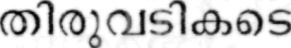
തിരുവടികടെ
